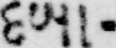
દબા
